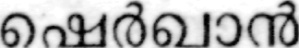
ഷെര്‍ഖാന്‍
